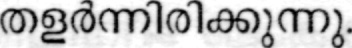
തളര്‍ന്നിരിക്കുന്നു.
